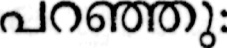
പറഞ്ഞു:
